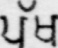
ਪੱਖ
